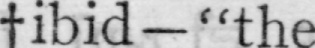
ibid-"the
